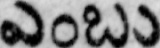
ಎಂಬು
